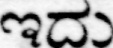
ಇದು
